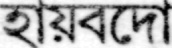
হায়বদো
